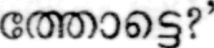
ത്തോട്ടെ?’
